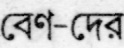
বেণ-দের
